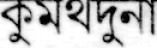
কুমথদুনা
